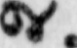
જ.
